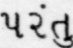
પરંતુ
